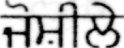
ਜੋਸ਼ੀਲੇ
